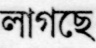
লাগছে
